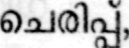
ചെരിപ്പ്,
